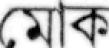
মোক
